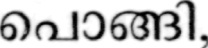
പൊങ്ങി,
